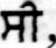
ਸੀ,
